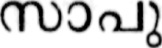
സാപു
